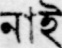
নাই
